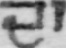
ਦਾ
